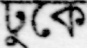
ঢুকে
